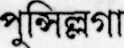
পুন্সিল্লগা
